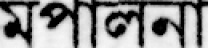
মপালনা
